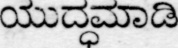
ಯುದ್ಧಮಾಡಿ
